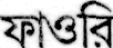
ফাওরি
